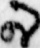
જે
